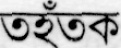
তহঁতক
